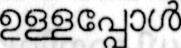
ഉള്ളപ്പോള്‍
